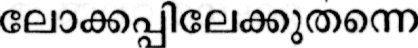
ലോക്കപ്പിലേക്കുതന്നെ
